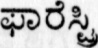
ಫಾರೆಸ್ಟ್ರಿ
